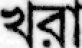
খরা
